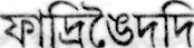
ফাদ্রিঙৈদদি
